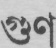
গুণ
